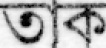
তাক
